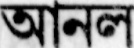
আনল
